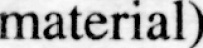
material)
